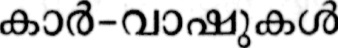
കാര്‍-വാഷുകള്‍
